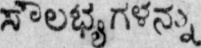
ಸೌಲಭ್ಯಗಳನ್ನು
